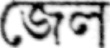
জেল
